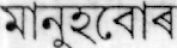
মানুহবোৰ
